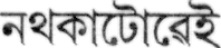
নথকাটোৱেই
